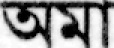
অমা
